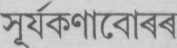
সূৰ্যকণাবোৰৰ
